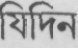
যিদিন
